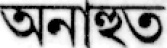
অনাহুত
